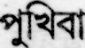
পুখিবা
